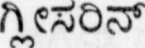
ಗ್ಲೀಸರಿನ್
